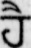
ਹੈ
